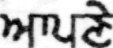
ਆਪਣੇ
